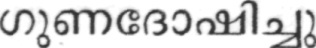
ഗുണദോഷിച്ചു
